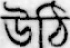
উঠি
